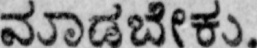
ಮಾಡಬೇಕು.
